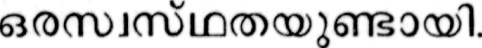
ഒരസ്വസ്ഥതയുണ്ടായി.
